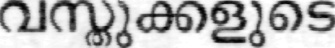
വസ്തുക്കളുടെ
